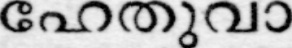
ഹേതുവാ
